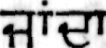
ਜਾਂਦਾ
